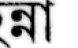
হন্না
